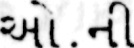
ઓ.ની
